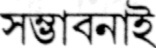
সম্ভাবনাই
